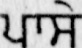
ਪਾਸੇ
